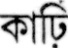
কাঢ়ি
